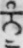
ਨੂੰ
